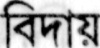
বিদায়
